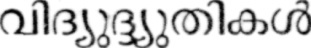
വിദ്യുദ്ദ്യുതികള്‍
